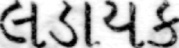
લડાયક
